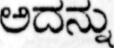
ಅದನ್ನು
